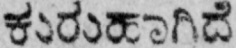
ಕುರುಹಾಗಿದೆ
